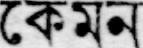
কেমন
